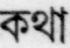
কথা
